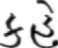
કહે
